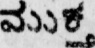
ಮುಕ್ತ
